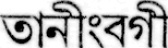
তানীংবগী
